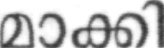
മാക്കി
